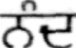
ਨੰਦ
